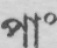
পা
